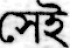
সেই
